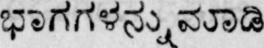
ಭಾಗಗಳನ್ನುಮಾಡಿ
